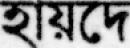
হায়দে
